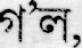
গ'ল,
